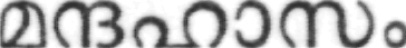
മന്ദഹാസം
